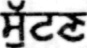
ਸੁੱਟਣ
